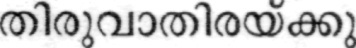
തിരുവാതിരയ്ക്കു
